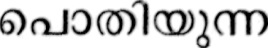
പൊതിയുന്ന
